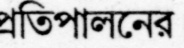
প্রতিপালনের
